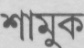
শামুক
